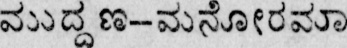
ಮುದ್ದಣ-ಮನೋರಮಾ
